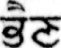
ਭੈਣ
